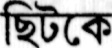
ছিটকে
